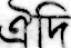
ঐদি
